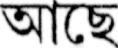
আছে
